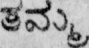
ತಮ್ಮ
